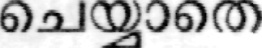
ചെയ്യാതെ
